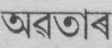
অৱতাৰ
